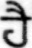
ਹੈ
